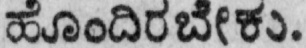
ಹೊಂದಿರಬೇಕು.
